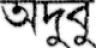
অদুবু
